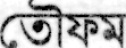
তৌফম
